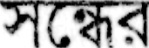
সন্ধের
